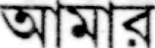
আমার
